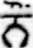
ਨੌਂ
